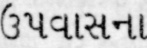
ઉપવાસના
